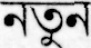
নতুন
